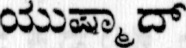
ಯುಷ್ಮಾದ್
